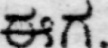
ಈಗ.
